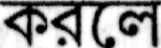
করলে
